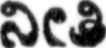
ನೀತಿ
